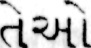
તેઓ
